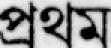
প্রথম
